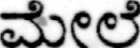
ಮೇಲೆ
